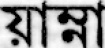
য়াম্না
